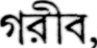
গরীব,
